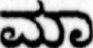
ಮಾ
